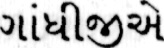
ગાંધીજીએ
